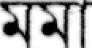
মমা
